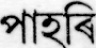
পাহৰি
